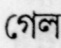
গেল
